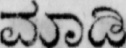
ಮಾಡಿ
